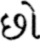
છો
